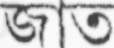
জাত
